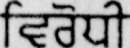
ਵਿਰੋਧੀ
